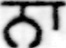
ਨਾ
